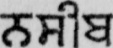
ਨਸੀਬ
